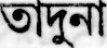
তাদুনা
